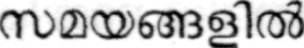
സമയങ്ങളില്‍
